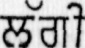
ਲੱਗੀ
